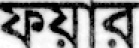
ফয়ার
